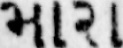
મારા
